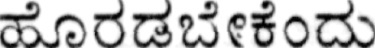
ಹೊರಡಬೇಕೆಂದು
